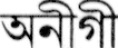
অনীগী
